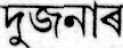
দুজনাৰ
